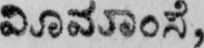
ಮೀಮಾಂಸೆ,
